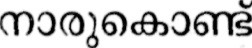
നാരുകൊണ്ട്
